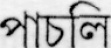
পাচলি
